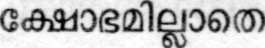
ക്ഷോഭമില്ലാതെ
